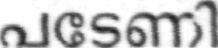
പടേണി
